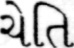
ચેતિ
